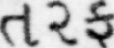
તરફ
